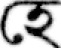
হে
